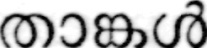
താങ്കള്‍
